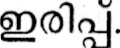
ഇരിപ്പ്.
